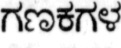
ಗಣಕಗಳ
